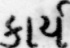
કાર્ય
